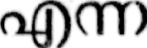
എന്ന
